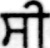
ਸੀ
